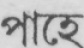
পাহে
